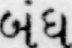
બંધ
